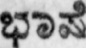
ಭಾಷೆ
